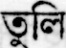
তুলি
